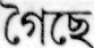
গৈছে
